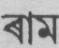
ৰাম
